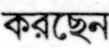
করছেন
